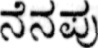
ನೆನಪು
